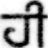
ਹੀ
